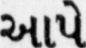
આપે
